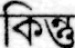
কিন্তু
